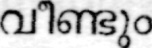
വീണ്ടും
